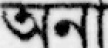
অনা
